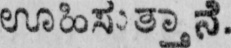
ಊಹಿಸುತ್ತಾನೆ.
